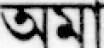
অমা
